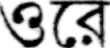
ওরে
